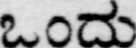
ಒಂದು
